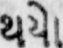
થયો
